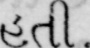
હતી.
